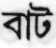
বাট
